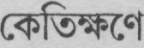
কেতিক্ষণে
